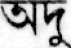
অদু
